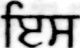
ਇਸ
